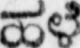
ಹಳೆ
